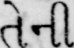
તેની
